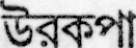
উরকপা
